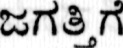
ಜಗತ್ತಿಗೆ
